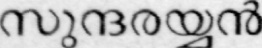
സുന്ദരയ്യന്‍
